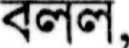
বলল,
